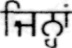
ਜਿਨ੍ਹਾਂ
